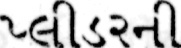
પ્લીડરની
